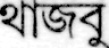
থাজবু
